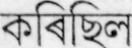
কৰিছিল
